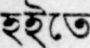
হইতে
